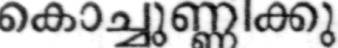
കൊച്ചുണ്ണിക്കു
